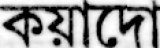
কয়াদো
